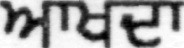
ਆਖਦਾ
